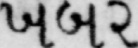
ખબર
